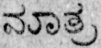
ಮಾತ್ರ
